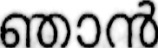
ഞാന്‍
